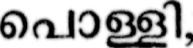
പൊള്ളി,
